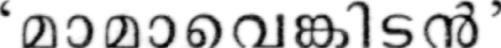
'മാമാവെങ്കിടന്‍'
